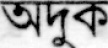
অদুক
